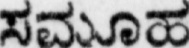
ಸಮೂಹ
